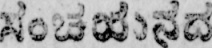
ಸಂಚಯನದ
